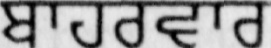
ਬਾਹਰਵਾਰ
